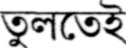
তুলতেই
